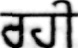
ਰਹੀ
